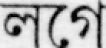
লগে
